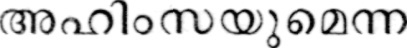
അഹിംസയുമെന്ന
